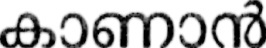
കാണാന്‍
